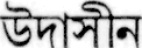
উদাসীন
